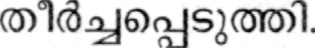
തീര്‍ച്ചപ്പെടുത്തി.
